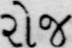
રોજ
